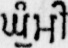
ਘੁੰਮੀ
